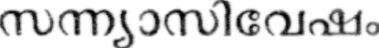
സന്ന്യാസിവേഷം
